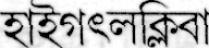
হাইগৎলক্লিবা
